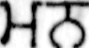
ਮਨ
